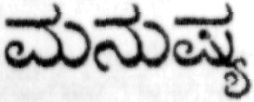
ಮನುಷ್ಯ
